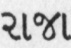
રાજા
